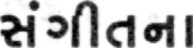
સંગીતના
